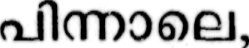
പിന്നാലെ,
